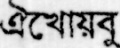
ঐখোয়বু
